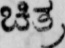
ಚಿತ್ರ
